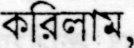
করিলাম,
